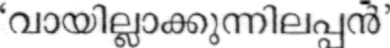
‘വായില്ലാക്കുന്നിലപ്പന്‍’
